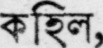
কহিল,
